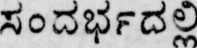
ಸಂದರ್ಭದಲ್ಲಿ
